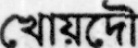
খোয়দৌ
